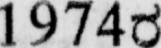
1974ರ
